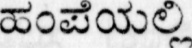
ಹಂಪೆಯಲ್ಲಿ
